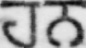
ਹਨ
